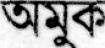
অমুক
